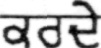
ਕਰਦੇ
